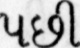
પછી
